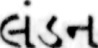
લંડન
